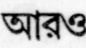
আরও
